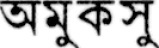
অমুকসু
